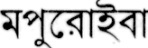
মপুরোইবা
